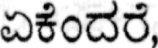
ಏಕೆಂದರೆ,
